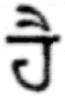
ਹੈ
